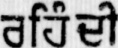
ਰਹਿੰਦੀ
